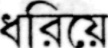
ধরিয়ে
